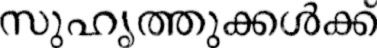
സുഹൃത്തുക്കള്‍ക്ക്
